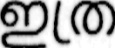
ഇത്ര
